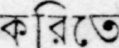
করিতে
